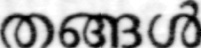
തങ്ങള്‍
